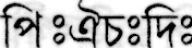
পিঃঐচঃদিঃ
